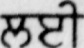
ਲਈ
